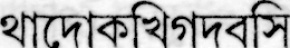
থাদোকখিগদবসি
